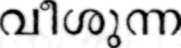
വീശുന്ന
